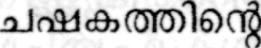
ചഷകത്തിന്റെ
